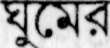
ঘুমের
